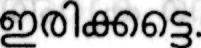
ഇരിക്കട്ടെ.
